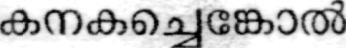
കനകച്ചെങ്കോല്‍
